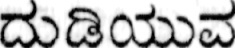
ದುಡಿಯುವ
